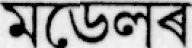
মডেলৰ
